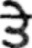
ਤੇ
